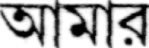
আমার
